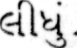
લીધું.
